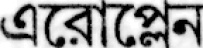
এরোপ্লেন
